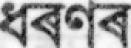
ধৰণৰ
